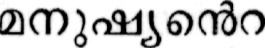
മനുഷ്യന്റെ
